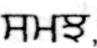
ਸਮਝ,
